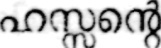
ഹസ്സന്റെ
